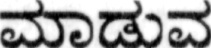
ಮಾಡುವ
